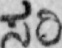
ಸರಿ
